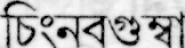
চিংনবগুম্বা
